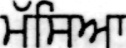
ਮੱਸਿਆ
